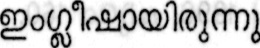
ഇംഗ്ലീഷായിരുന്നു
